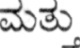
ಮತ್ತು
